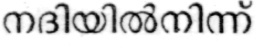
നദിയില്‍നിന്ന്
